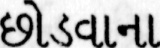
છોડવાના
